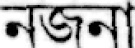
নজনা
